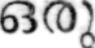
ഒരു
